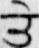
ਤੇ
